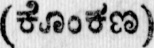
(ಕೊಂಕಣ)
